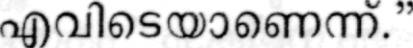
എവിടെയാണെന്ന്.”
